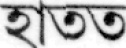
হাতত
